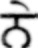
ਨੇ
